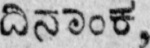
ದಿನಾಂಕ,
